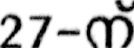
27-ന്
